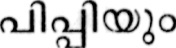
പിപ്പിയും
